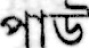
পাউ
